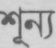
শূন্য
